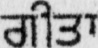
ਗੀਤਾ
